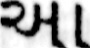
આ
